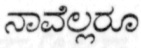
ನಾವೆಲ್ಲರೂ
